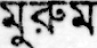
মুরুম
